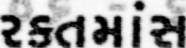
રક્તમાંસ
